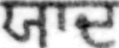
ਯਾਦ
